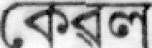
কেৱল
